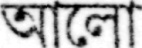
আলো
